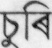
চুৰি
